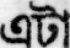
এটা
